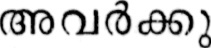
അവര്‍ക്കു
